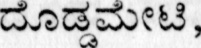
ದೊಡ್ಡಮೇಟಿ,
